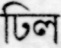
ঢিল
